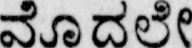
ಮೊದಲೇ
